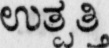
ಉತ್ಪತ್ತಿ
